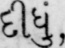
દીધું,
